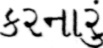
કરનારું
